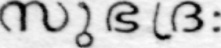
സുഭദ്ര:
